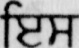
ਇਸ
